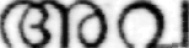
അവ
